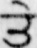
ਤੇ
